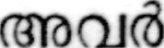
അവര്‍
